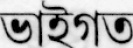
ভাইগত
